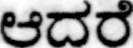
ಆದರೆ
